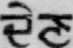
ਦੇਣ
